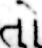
તો
